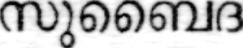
സുബൈദ
